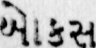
બોક્સ
